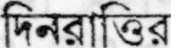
দিনরাত্তির
